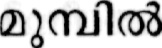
മുമ്പില്‍
